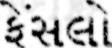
ફેંસલો
